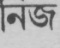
নিজ
